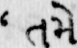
'તમે!
